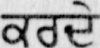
ਕਰਦੇ
